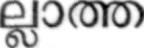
ല്ലാത്ത
